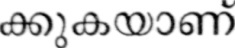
ക്കുകയാണ്
